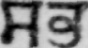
ਸਭ
